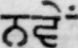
ਨਵੇਂ
